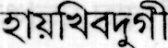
হায়খিবদুগী
